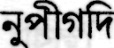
নুপীগদি
